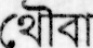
থৌবা
